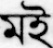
মই
